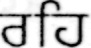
ਰਹਿ
